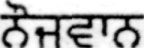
ਨੌਜਵਾਨ
